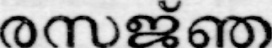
രസജ്ഞ
